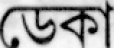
ডেকা
